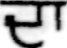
ਦਾ
